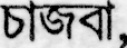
চাজবা,
